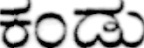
ಕಂಡು
